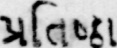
પ્રતિષ્ઠા
